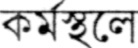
কর্মস্থলে
